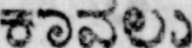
ಕಾವಲು
